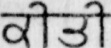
ਕੀਤੀ
